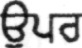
ਉਪਰ
